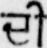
ਦੀ
